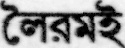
লৈরমই
